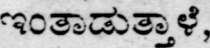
ಇಂತಾಡುತ್ತಾಳೆ,
